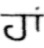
ਹਾਂ
